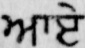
ਆਏ
